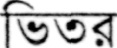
ভিতর
